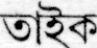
তাইক
